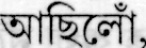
আছিলোঁ,
